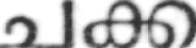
ചക്ക
